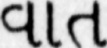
વાત
